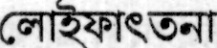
লোইফাৎতনা
